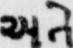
અને
